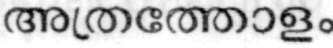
അത്രത്തോളം
